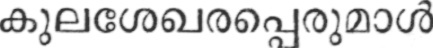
കുലശേഖരപ്പെരുമാള്‍
